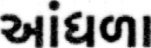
આંધળા
